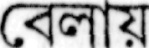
বেলায়
